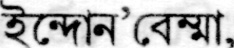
ইন্দোন’বেম্মা,
